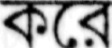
করে
